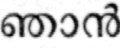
ഞാന്‍
